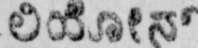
ಲಿಯೋನ್
